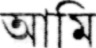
আমি
